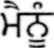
ਮੈਨੂੰ
